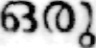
ഒരു
